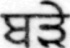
ਬੜੇ
